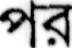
পর
